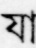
যা
